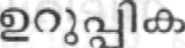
ഉറുപ്പിക
